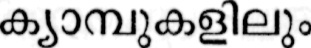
ക്യാമ്പുകളിലും
